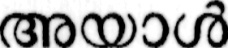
അയാള്‍
